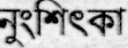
নুংশিৎকা
